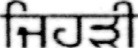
ਜਿਹੜੀ
